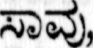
ಸಾವು,
